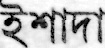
ইশাদা
